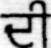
ਦੀ
